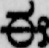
ಈ
